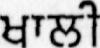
ਖਾਲੀ
